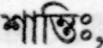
শান্তিঃ,
